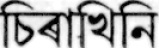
চিৰাখিনি
